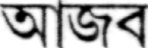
আজব
